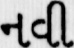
નવી
